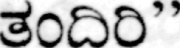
ತಂದಿರಿ"
